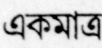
একমাত্র
